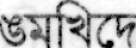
ঙমখিদে
